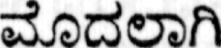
ಮೊದಲಾಗಿ
